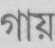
গায়
